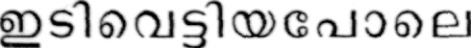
ഇടിവെട്ടിയപോലെ
